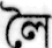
লৈ
